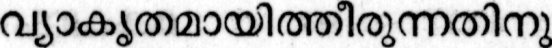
വ്യാകൃതമായിത്തീരുന്നതിനു
